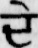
ਦੇ
